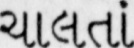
ચાલતાં
